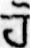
ਹੋ
